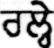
ਰਲ੍ਹੇ
